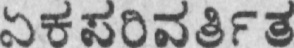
ಏಕಪರಿವರ್ತಿತ
